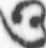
ও
